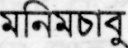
মনিমচাবু
